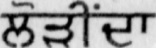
ਲੋੜੀਂਦਾ
